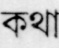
কথা
